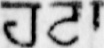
ਹਟਾ
